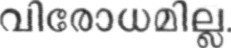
വിരോധമില്ല.
